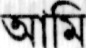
আমি
